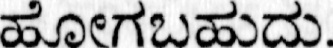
ಹೋಗಬಹುದು.
